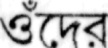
ওঁদের
